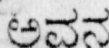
ಅವನ
